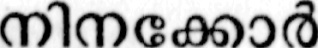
നിനക്കോര്‍
